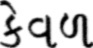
કેવળ
